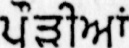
ਪੌੜੀਆਂ
